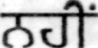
ਨਹੀਂ
